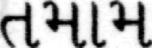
તમામ
